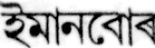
ইমানবোৰ
